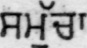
ਸਮੁੱਚਾ
